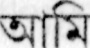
আমি
